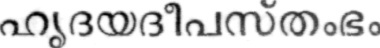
ഹൃദയദീപസ്തംഭം
